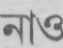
নাও
